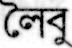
লৈবু
